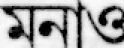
মনাও
